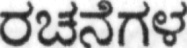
ರಚನೆಗಳ
